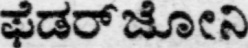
ಫೆಡರ್‌ಜೋನಿ
